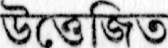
উত্তেজিত
